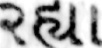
રહ્યા
